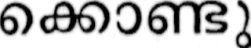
ക്കൊണ്ടു
